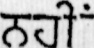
ਨਹੀਂ
